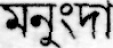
মনুংদা
